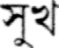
সুখ
